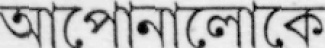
আপোনালোকে
